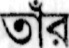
তাঁর
